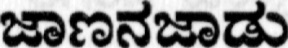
ಜಾಣನಜಾಡು
